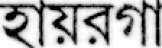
হায়রগা
